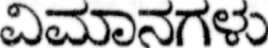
ವಿಮಾನಗಳು
